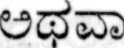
ಅಥವಾ
